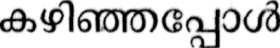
കഴിഞ്ഞപ്പോള്‍
